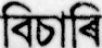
বিচাৰি
